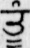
ਤੂੰ
